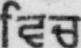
ਵਿਚ
